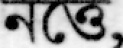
নত্তে,
